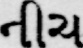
નીચ
